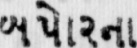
બપોરના
